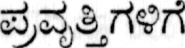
ಪ್ರವೃತ್ತಿಗಳಿಗೆ
